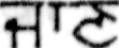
ਜਾਣ
